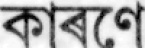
কাৰণে
